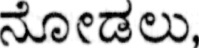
ನೋಡಲು,
